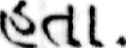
હતા.
